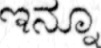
ಇನ್ನೂ
